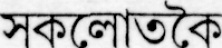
সকলোতকৈ
